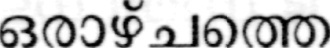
ഒരാഴ്ചത്തെ
